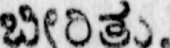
ಬೀರಿತು.
